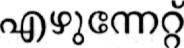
എഴുന്നേറ്റ്
